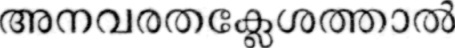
അനവരതക്ലേശത്താല്‍
